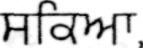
ਸਕਿਆ,
